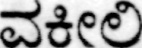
ವಕೀಲಿ
